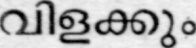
വിളക്കും
